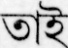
তাই
